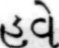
હવે
